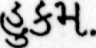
હુકમ.
